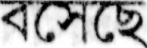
বসেছে
